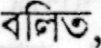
বলিত,
